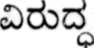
ವಿರುದ್ಧ
